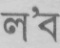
ল'ব
